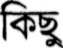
কিছু
